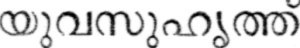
യുവസുഹൃത്ത്
